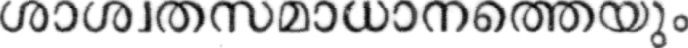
ശാശ്വതസമാധാനത്തെയും
